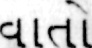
વાતો
